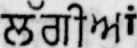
ਲੱਗੀਆਂ
